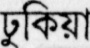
ঢুকিয়া
